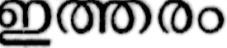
ഇത്തരം
